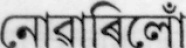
নোৱাৰিলোঁ
